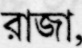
রাজা,
